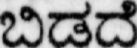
ಬಿಡದೆ
